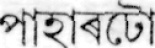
পাহাৰটো
